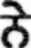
ਨੇ
